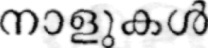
നാളുകള്‍
